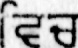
ਵਿਚ
